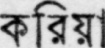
করিয়া
